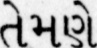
તેમણે
